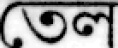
তেল
